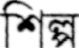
শিল্প
